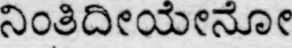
ನಿಂತಿದೀಯೇನೋ
